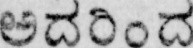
ಅದರಿಂದ
